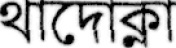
থাদোক্না
